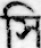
সি
